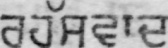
ਰਹੱਸਵਾਦ
